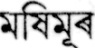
মষিমূৰ
